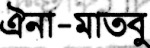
ঐনা-মাতবু
